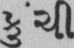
કુંચી
